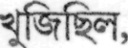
খুজিছিল,
